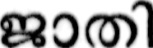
ജാതി
